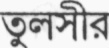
তুলসীর
